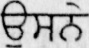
ਉਸਨੇ
